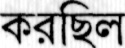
করছিল
